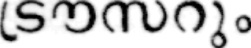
ട്രൌസറും
